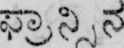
ಫ್ರಾನ್ಸಿನ
